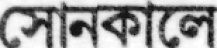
সোনকালে
